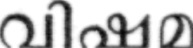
വിഷമ
